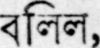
বলিল,
